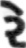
રે
